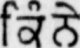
ਕਿੰਨੇ
